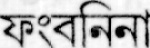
ফংবনিনা
